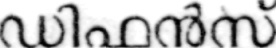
ഡിഫന്‍സ്
